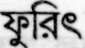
ফুরিৎ
